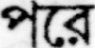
পরে
